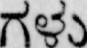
ಗಳು
